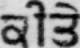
ਕੀਤੇ
